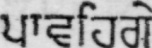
ਪਾਵਹਿਗੇ
